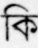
কি
